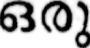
ഒരു
